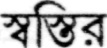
স্বস্তির
